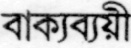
বাক্যব্যয়ী
